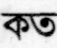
কত
